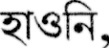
হাওনি,
